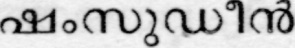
ഷംസുഡീന്‍
